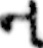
ન
